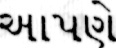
આપણે
